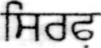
ਸਿਰਫ਼
